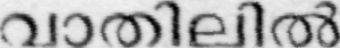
വാതിലില്‍
